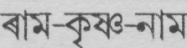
ৰাম-কৃষ্ণ-নাম
